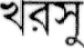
খরসু
